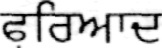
ਫ਼ਰਿਆਦ
